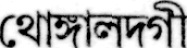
থোঙ্গালদগী
